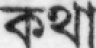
কথা
